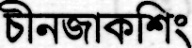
চীনজাকশিং
